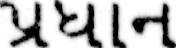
પ્રધાન
